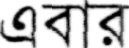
এবার
